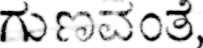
ಗುಣವಂತೆ,
